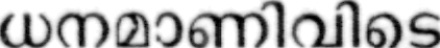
ധനമാണിവിടെ
